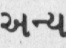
અન્ય
